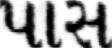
પાસ
